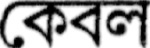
কেবল
